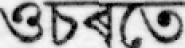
ওচৰতে
